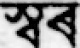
স্বৰ
